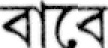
বাবে
